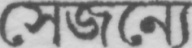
সেজন্যে
